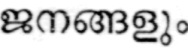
ജനങ്ങളും
